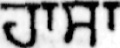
ਹਾਸਾ
